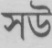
সউ
